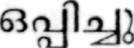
ഒപ്പിച്ചു
